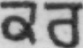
ਕਰ
